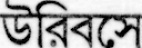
উরিবসে
